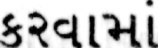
કરવામાં
